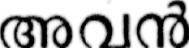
അവന്‍
